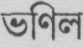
ভণিল
